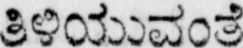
ತಿಳಿಯುವಂತೆ
